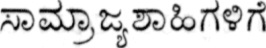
ಸಾಮ್ರಾಜ್ಯಶಾಹಿಗಳಿಗೆ
